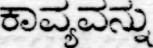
ಕಾವ್ಯವನ್ನು
